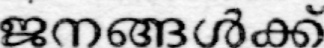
ജനങ്ങള്‍ക്ക്
